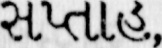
સપ્તાહ,
